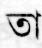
তা
